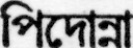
পিদোন্না
